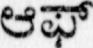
ಆಫ್
